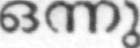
ഒന്നു
